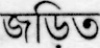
জড়িত
